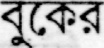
বুকের
